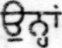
ਉਨ੍ਹਾਂ
